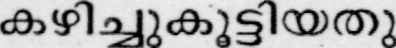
കഴിച്ചുകൂട്ടിയതു
